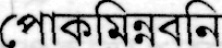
পোকমিন্নবনি
